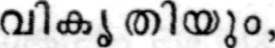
വികൃതിയും,
